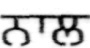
ਨਾਲ
